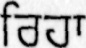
ਰਿਹਾ
